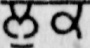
ਲੁਕ
